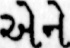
એને
